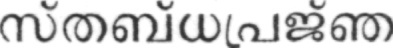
സ്തബ്ധപ്രജ്ഞ
